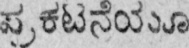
ಪ್ರಕಟನೆಯೂ
